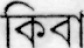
কিবা
